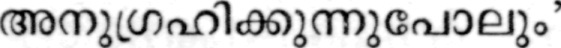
അനുഗ്രഹിക്കുന്നുപോലും'
